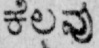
ಕೆಲವು
